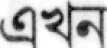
এখন
